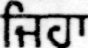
ਜਿਹਾ
